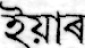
ইয়াৰ
